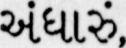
અંધારું,
